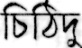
চিঠিদু
